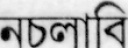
নচলাবি
